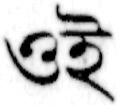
ওই
